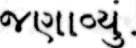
જણાવ્યું.
